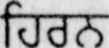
ਹਿਰਨ
